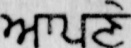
ਆਪਣੇ
